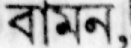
বামন,
